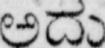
ಅದು
